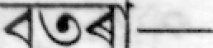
বতৰা-
